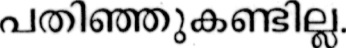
പതിഞ്ഞുകണ്ടില്ല.
